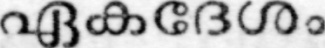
ഏകദേശം
